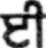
ਈ
